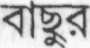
বাছুর
